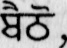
ਬੈਠੋ,
